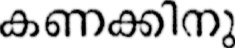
കണക്കിനു
